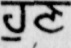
ਹੁਣ
